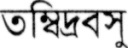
তম্বিদ্রবসু
